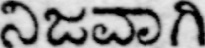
ನಿಜವಾಗಿ
